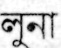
লুনা
